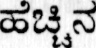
ಹೆಚ್ಚಿನ
